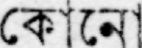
কোনো
